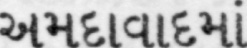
અમદાવાદમાં
